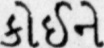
કોઈને
